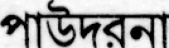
পাউদরনা
